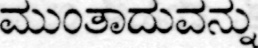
ಮುಂತಾದುವನ್ನು
